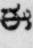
ಈ
